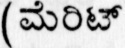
(ಮೆರಿಟ್
